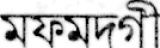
মফমদগী
